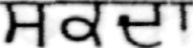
ਸਕਦਾ
